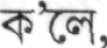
ক'লে,
